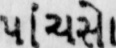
પાંચસો
